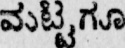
ಮಟ್ಟಿಗೂ
